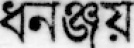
ধনঞ্জয়
